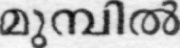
മുമ്പില്‍
